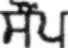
ਸੌਂਪ
